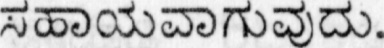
ಸಹಾಯವಾಗುವುದು.
